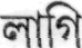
লাগি
